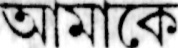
আমাকে
